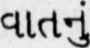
વાતનું
